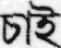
চাই
